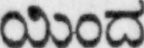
ಯಿಂದ
